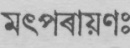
মৎপৰায়ণঃ
